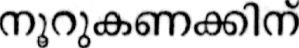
നൂറുകണക്കിന്
